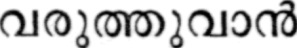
വരുത്തുവാന്‍
